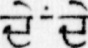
ਦੇਂਦੇ
